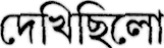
দেখিছিলো
